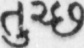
તુચ્છ
